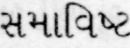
સમાવિષ્ટ
